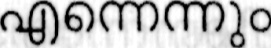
എന്നെന്നും
